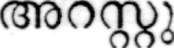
അറസ്റ്റു
